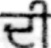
ਦੀ
